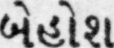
બેહોશ
